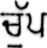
ਚੁੱਪ
